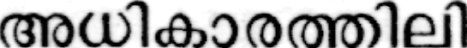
അധികാരത്തിലി
